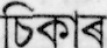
চিকাৰ
